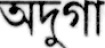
অদুগা
